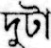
দুটা
